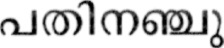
പതിനഞ്ചു
